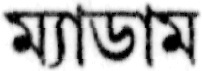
ম্যাডাম
